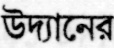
উদ্যানের
